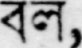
বল,
